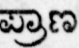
ಪ್ರಾಣ
